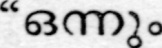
"ഒന്നും
